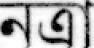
নত্রা
